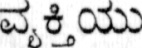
ವ್ಯಕ್ತಿಯು
